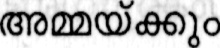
അമ്മയ്ക്കും
